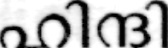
ഹിന്ദി
